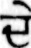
ਦੇ
